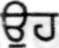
ਉਹ
